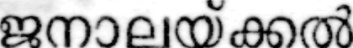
ജനാലയ്ക്കല്‍
